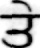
ਤੇ
